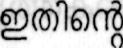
ഇതിന്റെ
